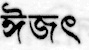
ঈজৎ
